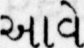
આવે
